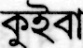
কুইবা
